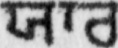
ਯਾਰ
